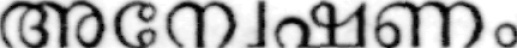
അന്വേഷണം
